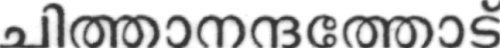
ചിത്താനന്ദത്തോട്
